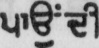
ਪਾਉਂਦੀ
